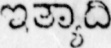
ಇತ್ಯಾದಿ
